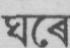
ঘৰে
